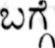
ಬಗ್ಗೆ
